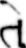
તે
